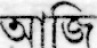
আজি
